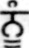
ਨੂੰ
